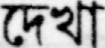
দেখা
